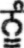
ਨੂੰ
